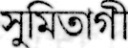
সুমিতাগী
